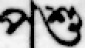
পশু
